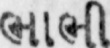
ભાભી
